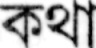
কথা
